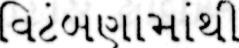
વિટંબણામાંથી
